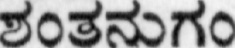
ಶಂತನುಗಂ
